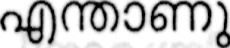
എന്താണു
